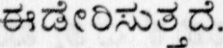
ಈಡೇರಿಸುತ್ತದೆ.
